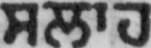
ਸਲਾਹ
